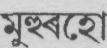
মুহুৰহো
